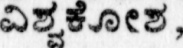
ವಿಶ್ವಕೋಶ,
